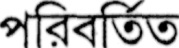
পরিবর্তিত
